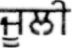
ਜੂਲੀ
